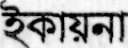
ইকায়না
